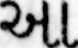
આ
